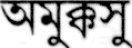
অমুক্কসু
